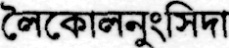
লৈকোলনুংসিদা
